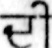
ਦੀ
